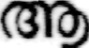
ആ
